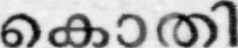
കൊതി
